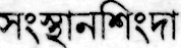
সংস্থানশিংদা
